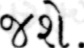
જશે.
